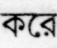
করে
